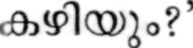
കഴിയും?'
